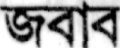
জবাব
